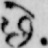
છે.
